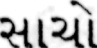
સાચો
